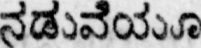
ನಡುವೆಯೂ
